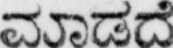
ಮಾಡದೆ
